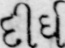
દીર્ઘ
